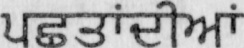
ਪਛਤਾਂਦੀਆਂ
